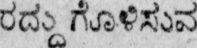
ರದ್ದುಗೊಳಿಸುವ
